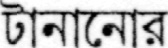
টানানোর
